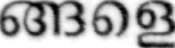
ങ്ങളെ
